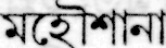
মহৌশানা
